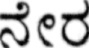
ನೇರ
